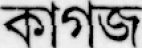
কাগজ
